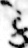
કે
